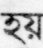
হয়
